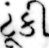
ટૂંકી
